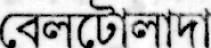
বেলটোলাদা
